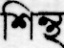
শিন্থ
